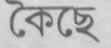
কৈছে
